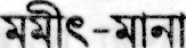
মমীৎ-মানা
